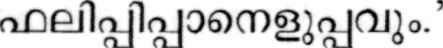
ഫലിപ്പിപ്പാനെളുപ്പവും.'
